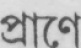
প্ৰাণে
